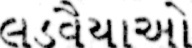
લડવૈયાઓ
